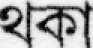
থকা
